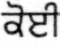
ਕੋਈ
